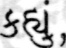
કહ્યું,
